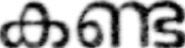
കണ്ട
